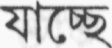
যাচ্ছে
